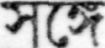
সঙ্গে
